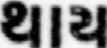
થાય
